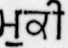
ਮੁਕੀ
